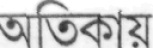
অতিকায়
